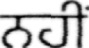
ਨਹੀਂ
